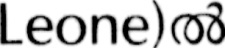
Leone)ല്‍
